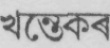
খন্তেকৰ
